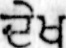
ਦੇਖ
